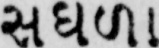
સઘળા
